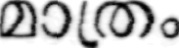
മാത്രം
